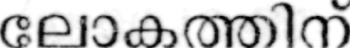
ലോകത്തിന്
